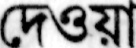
দেওয়া
